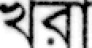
খরা
